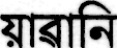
য়াৱানি
